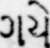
ગયે
